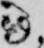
છે.
